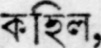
কহিল,
